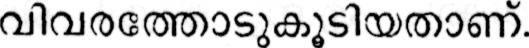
വിവരത്തോടുകൂടിയതാണ്.
